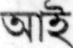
আই
